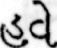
હવે
